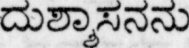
ದುಶ್ಯಾಸನನು
